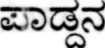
ಪಾಡ್ಡನ
